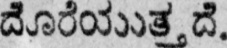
ದೊರೆಯುತ್ತದೆ.
